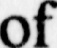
of
